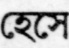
হেসে
